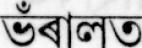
ভঁৰালত
